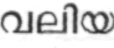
വലിയ
